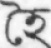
হৈ
